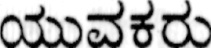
ಯುವಕರು
